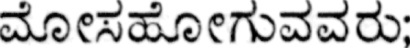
ಮೋಸಹೋಗುವವರು;
